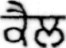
ਕੈਲ
